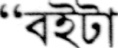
“বইটা
